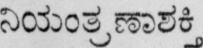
ನಿಯಂತ್ರಣಾಶಕ್ತಿ
